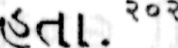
હતા.૨૦૨
